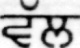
ਵੱਲ
